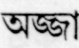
অজ্জা
